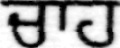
ਚਾਹ
